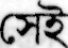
সেই
